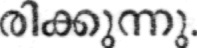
രിക്കുന്നു.
